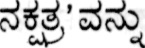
ನಕ್ಷತ್ರ'ವನ್ನು
